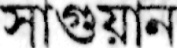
সাগুয়ান
